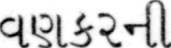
વણકરની
